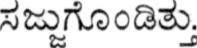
ಸಜ್ಜುಗೊಂಡಿತ್ತು.
